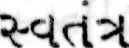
સ્વતંત્ર
